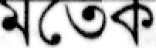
মতেক
